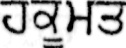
ਹਕੂਮਤ
